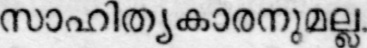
സാഹിത്യകാരനുമല്ല.
